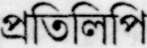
প্রতিলিপি
